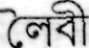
লৈবী
